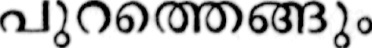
പുറത്തെങ്ങും
